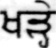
ਖੜ੍ਹੇ
